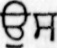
ਉਸ
